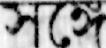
সঙ্গে
